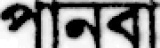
পানবা
